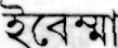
ইবেম্মা
